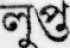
লুপ্ত
